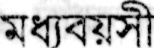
মধ্যবয়সী
